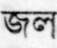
জল
